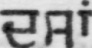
ਦਸਾਂ
